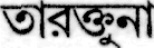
তারক্তুনা
